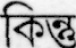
কিন্তু
